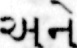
અને
